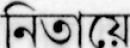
নিতায়ে
